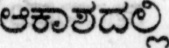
ಆಕಾಶದಲ್ಲಿ
